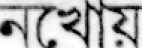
নখোয়
